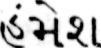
હંમેશ
